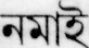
নমাই
